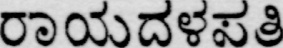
ರಾಯದಳಪತಿ
